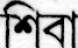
শিবা
